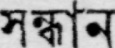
সন্ধান
